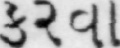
કરવા
